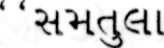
"સમતુલા
